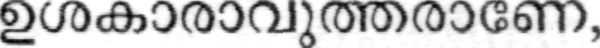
ഉശകാരാവുത്തരാണേ,
